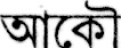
আকৌ
